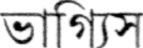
ভাগ্যিস
